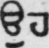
ਉਹ
